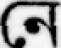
নে
